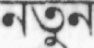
নতুন
